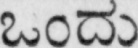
ಒಂದು
